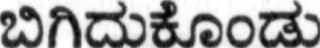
ಬಿಗಿದಿಕೊ೦ಡು
